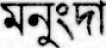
মনুংদা
